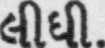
લીધી.
